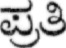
ಪ್ರತಿ
